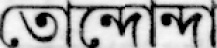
তোন্দোন্দা
